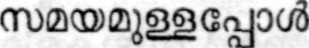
സമയമുള്ളപ്പോള്‍
